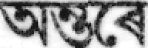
অন্তৰে
